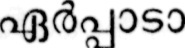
ഏര്‍പ്പാടാ
